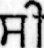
ਸੀ
